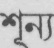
শূন্য
